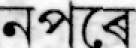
নপৰে
